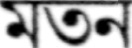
মতন
